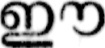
ഈ
